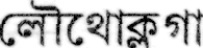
লৌথোক্লগা
